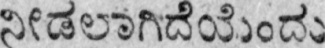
ನೀಡಲಾಗಿದೆಯೆಂದು
